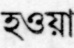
হওয়া
